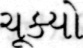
ચૂક્યો
